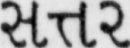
સત્તર
